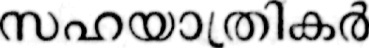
സഹയാത്രികര്‍
